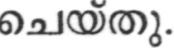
ചെയ്തു.
